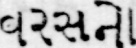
વરસનો
